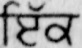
ਇੱਕ
